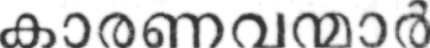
കാരണവന്മാര്‍
